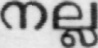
നല്ല
